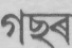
গছৰ
